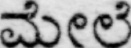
ಮೇಲೆ
